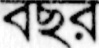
বছর
